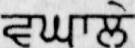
ਵਘਾਲੇ
